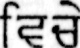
ਵਿਚੇ
